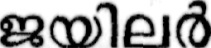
ജയിലര്‍
